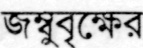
জম্বুবৃক্ষের
